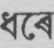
ধৰে
